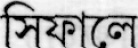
সিফালে
